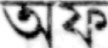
অফ
